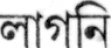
লাগনি
